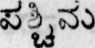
ಪಶ್ಚಿಮ
